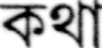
কথা
